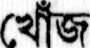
খোঁজ
